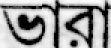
ভারা
